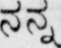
ನನ್ನ
